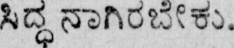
ಸಿದ್ಧನಾಗಿರಬೇಕು.
